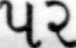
પર
